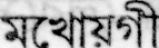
মখোয়গী
